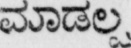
ಮಾಡಲ್ಪ
